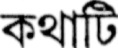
কথাটি
